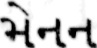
મેનન
